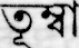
তূম্বা
